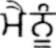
ਮੈਨੂੰ
